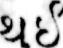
થઇ
